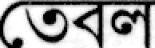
তেবল
